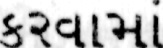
કરવામાં
